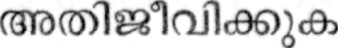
അതിജീവിക്കുക
